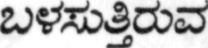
ಬಳಸುತ್ತಿರುವ
